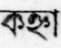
কহ্না
